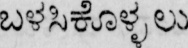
ಬಳಸಿಕೊಳ್ಳಲು
